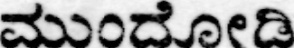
ಮುಂದೋಡಿ
